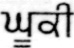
ਘੂਕੀ
